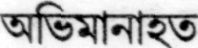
অভিমানাহত
